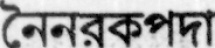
নৈনরকপদা
